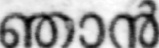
ഞാന്‍
